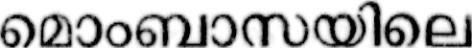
മൊംബാസയിലെ
